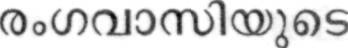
രംഗവാസിയുടെ
